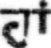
ਹਾਂ
